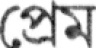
প্রেম
